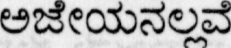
ಅಜೇಯನಲ್ಲವೆ
